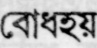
বোধহয়
